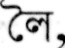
লৈ,
